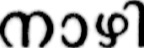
നാഴി
